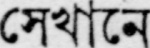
সেখানে
